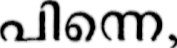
പിന്നെ,
